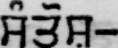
ਸੰਤੋਸ਼-
